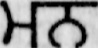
ਮਨ
